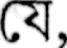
যে,
